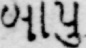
બાપુ
